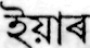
ইয়াৰ
